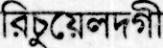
রিচুয়েলদগী
